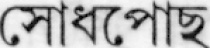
সোধপোছ
